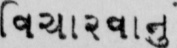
વિચારવાનું
